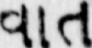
વાત
